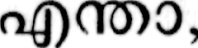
എന്താ,
